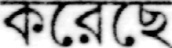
করেছে
